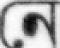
নে
